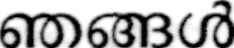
ഞങ്ങള്‍
